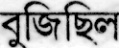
বুজিছিল
